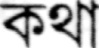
কথা
